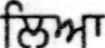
ਲਿਆ
